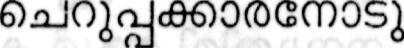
ചെറുപ്പക്കാരനോടു
